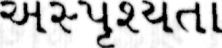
અસ્પૃશ્યતા
